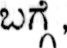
ಬಗ್ಗೆ,
